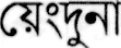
য়েংদুনা
